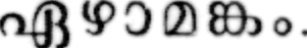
ഏഴാമങ്കം.
